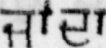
ਜਾਂਦਾ
